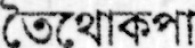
তৈথোকপা
